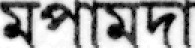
মপামদা
